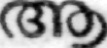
ആ
